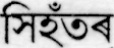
সিহঁতৰ
